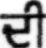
ਦੀ
